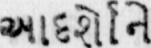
આદર્શોને
